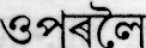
ওপৰলৈ
